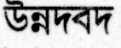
উন্নদবদ
